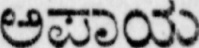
ಅಪಾಯ
